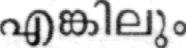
എങ്കിലും
